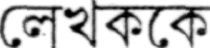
লেখককে
